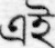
এই
